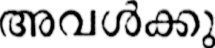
അവള്‍ക്കു
